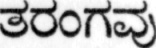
ತರಂಗವು
